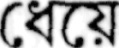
ধেয়ে
